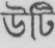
উটি
